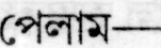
পেলাম-
